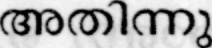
അതിന്നു
